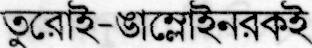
তুরোই-ঙাম্লোইনরকই
